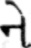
ને
